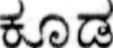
ಕೂಡ
